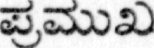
ಪ್ರಮುಖ
